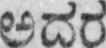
ಅದರ
